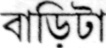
বাড়িটা
